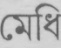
মেধি
